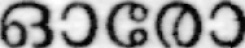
ഓരോ
